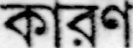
কারণ
